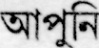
আপুনি
